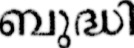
ബുദ്ധി
